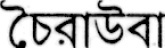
চৈরাওবা
